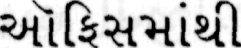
ઑફિસમાંથી
